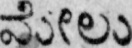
ಮೇಲು
